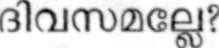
ദിവസമല്ലേ?
